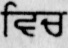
ਵਿਚ
